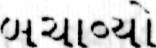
બચાવ્યો
